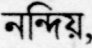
নন্দিয়,
